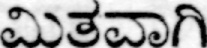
ಮಿತವಾಗಿ
